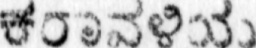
ಕರಾವಳಿಯ
